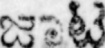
ಜಾಟ
